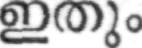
ഇതും
